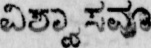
ವಿಶ್ವಾಸವೂ
